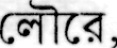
লৌরে,
